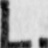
L.
